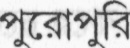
পুরোপুরি
